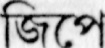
জিপে
